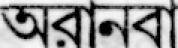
অরানবা
